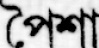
পৈশা
